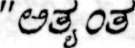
“ಅತ್ಯಂತ
